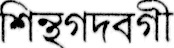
শিন্থগদবগী
